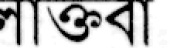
লাক্তবা
